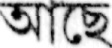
আছে
